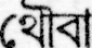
থৌবা
